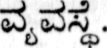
ವ್ಯವಸ್ಥೆ.
